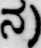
ನ)
